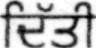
ਦਿੱਤੀ
